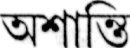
অশান্তি
